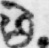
છે.
